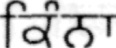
ਕਿੰਨਾ
